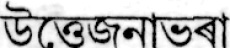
উত্তেজনাভৰা
